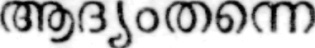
ആദ്യംതന്നെ
